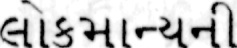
લોકમાન્યની
